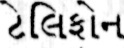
ટેલિફોન
